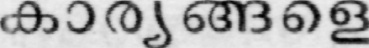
കാര്യങ്ങളെ
